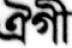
ঐগী
